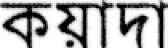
কয়াদা
